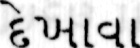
દેખાવા
